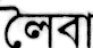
লৈবা
